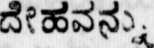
ದೇಹವನ್ನು
